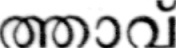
ത്താവ്
